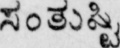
ಸಂತುಷ್ಟಿ
